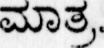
ಮಾತ್ರ.
